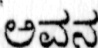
ಅವನ
